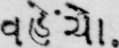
વહેંચો.
